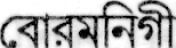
বোরমনিগী
